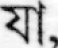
যা,
